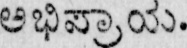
ಅಭಿಪ್ರಾಯ.
